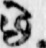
છે.
